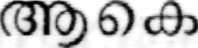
ആകെ
